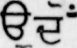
ਉਦੋਂ
